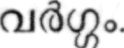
വര്‍ഗ്ഗം.
